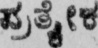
ಪ್ರತ್ಯೇಕ
